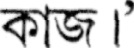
কাজ।'
